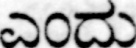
ಎಂದು
